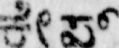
ಕೇಪ್
